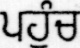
ਪਹੁੰਚ
